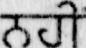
ਨਹੀਂ
